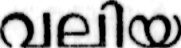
വലിയ
